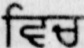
ਵਿਚ
